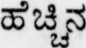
ಹೆಚ್ಚಿನ
